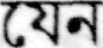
যেন
